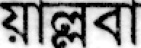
য়াল্লবা
